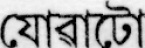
যোৱাটো
